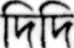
দিদি
